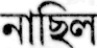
নাছিল
